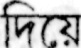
দিয়ে
